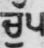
ਚੁੱਪ
